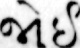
જોઈ
